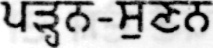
ਪੜ੍ਹਨ-ਸੁਣਨ
